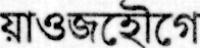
য়াওজহৌগে
